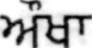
ਔਖਾ
